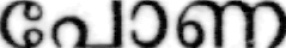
പോണ
